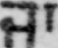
ਜਾ
